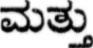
ಮತ್ತು
